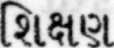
શિક્ષણ
